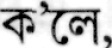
ক'লে,
